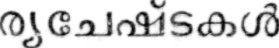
ര്യചേഷ്ടകള്‍
